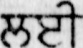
ਲਈ
